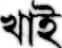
খাই
